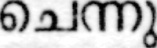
ചെന്നു
